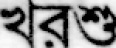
খরসু
